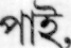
পাই,
